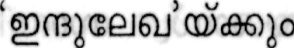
'ഇന്ദുലേഖ'യ്ക്കും
